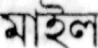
মাইল
